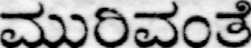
ಮುರಿವಂತೆ
